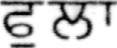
ਫੁਲਾ
